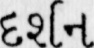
દર્શન
